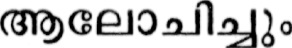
ആലോചിച്ചും
